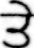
ਤੇ
